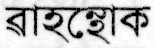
ৱাহন্থোক
